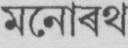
মনোৰথ
